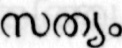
സത്യം
